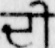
ਦੀ
